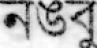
নঙবু
